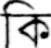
কি
